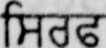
ਸਿਰਫ
